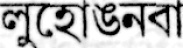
লুহোঙনবা
